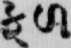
ફળ
